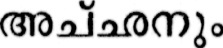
അച്ഛനും
